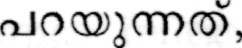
പറയുന്നത്,
